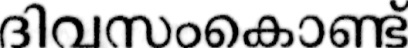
ദിവസംകൊണ്ട്
